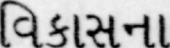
વિકાસના
